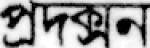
প্রদক্সন
